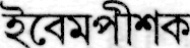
ইবেমপীশক
